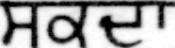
ਸਕਦਾ
